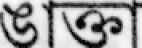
ঙাক্তা
